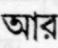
আর
